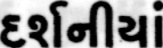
દર્શનીયાં
